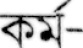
কর্ম-
